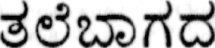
ತಲೆಬಾಗದ
